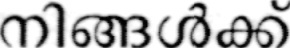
നിങ്ങള്‍ക്ക്
